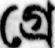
গ্রে
